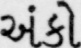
અંકો
